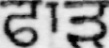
ਫਾੜ
